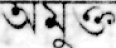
অমুক্ত
